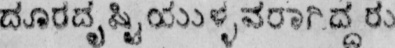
ದೂರದೃಷ್ಟಿಯುಳ್ಳವರಾಗಿದ್ದರು
